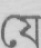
যে
